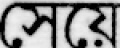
সেয়ে
